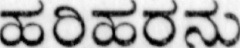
ಹರಿಹರನು
